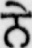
ਨੇ
